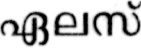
ഏലസ്
